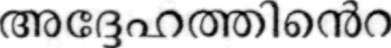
അദ്ദേഹത്തിന്റെ
